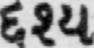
દ્દશ્ય
